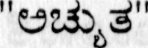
“ಅಚ್ಯುತ”
